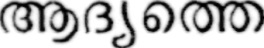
ആദ്യത്തെ
